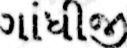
ગાંધીજી
